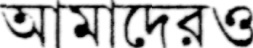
আমাদেরও
